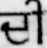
ਦੀ
